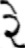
રે
